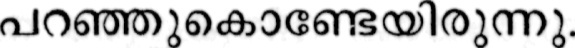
പറഞ്ഞുകൊണ്ടേയിരുന്നു.
